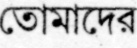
তোমাদের
